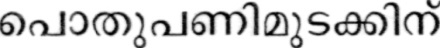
പൊതുപണിമുടക്കിന്
